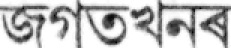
জগতখনৰ
